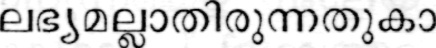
ലഭ്യമല്ലാതിരുന്നതുകാ
